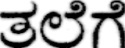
ತಲೆಗೆ
